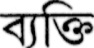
ব্যক্তি
